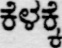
ಕೆಳಕ್ಕೆ
